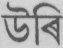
উৰি
